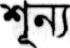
শূন্য
